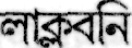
লাক্লবনি
